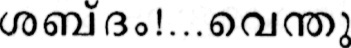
ശബ്ദം!...വെന്തു
